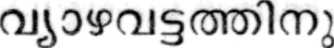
വ്യാഴവട്ടത്തിനു
